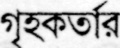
গৃহকর্তার
